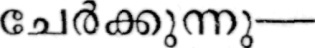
ചേര്‍ക്കുന്നു-
